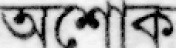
অশোক
